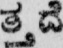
ತ್ತದೆ.
